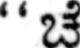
"ಚೆ
